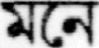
মনে
